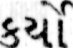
કર્યો
